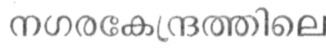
നഗരകേന്ദ്രത്തിലെ
